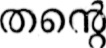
തന്റെ
